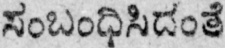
ಸಂಬಂಧಿಸಿದಂತೆ
